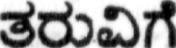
ತರುವಿಗೆ
